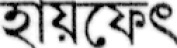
হায়ফেৎ
